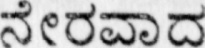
ನೇರವಾದ
